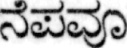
ನೆಪವೂ
